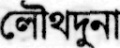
লৌথদুনা
